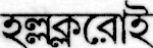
হল্লক্লরোই
